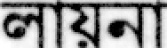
লায়না
